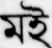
মই
